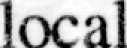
local
